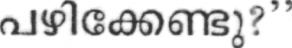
പഴിക്കേണ്ടു?"
